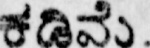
ಕಡಿಮೆ.
